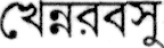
খেন্নরবসু
